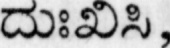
ದುಃಖಿಸಿ,
